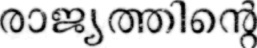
രാജ്യത്തിന്റെ
